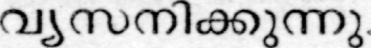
വ്യസനിക്കുന്നു.
